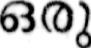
ഒരു
